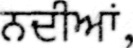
ਨਦੀਆਂ,
